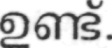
ഉണ്ട്.
